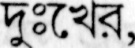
দুঃখের,
